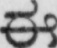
ಈ
